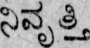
ನಿವೃತ್ತಿ
